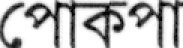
পোকপা
